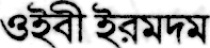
ওইবী
